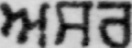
ਅਸਰ
